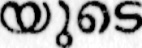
യുടെ
